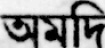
অমদি
